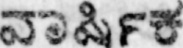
ವಾರ್ಷಿಕ
